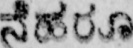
ನೆಹರೂ
